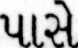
પાસે
